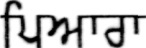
ਪਿਆਰਾ
